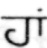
ਹਾਂ
